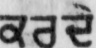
ਕਰਦੇ
